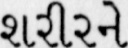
શરીરને
